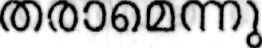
തരാമെന്നു
